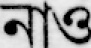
নাও
